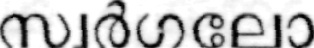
സ്വര്‍ഗലോ
